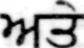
ਅਤੇ
